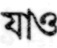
যাও
